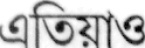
এতিয়াও
